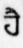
ਹੈ
